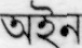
অইন
